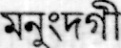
মনুংদগী
